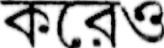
করেও
